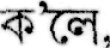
ক'লে,
